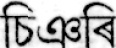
চিঞৰি
